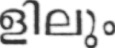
ളിലും
